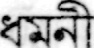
ধমনী
